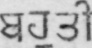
ਬਹੁਤੀ
